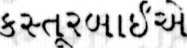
કસ્તૂરબાઇએ
